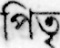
পিতৃ
